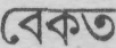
বেকত
